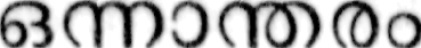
ഒന്നാന്തരം
